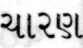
ચારણ
